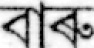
বাৰু
